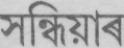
সন্ধিয়াৰ
